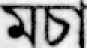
মচা
